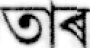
তাৰ
